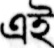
এই
